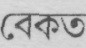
বেকত
